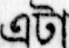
এটা
